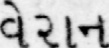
વેરાન
